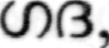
ഗദ,
